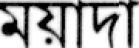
ময়াদা
